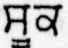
ਸੂਕ
